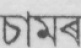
চামৰ
